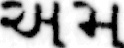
અમ
